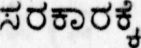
ಸರಕಾರಕ್ಕೆ
